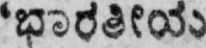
‘ಭಾರತೀಯ
